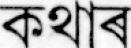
কথাৰ
